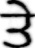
ਤੇ
